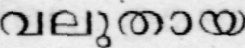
വലുതായ
